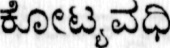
ಕೋಟ್ಯವಧಿ
